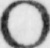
O
